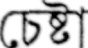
চেষ্টা
